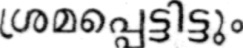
ശ്രമപ്പെട്ടിട്ടും
